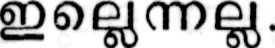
ഇല്ലെന്നല്ല.
